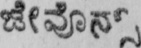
ಜೇವೊನ್ಸ್
